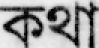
কথা
